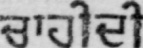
ਚਾਹੀਦੀ
